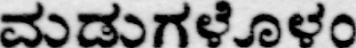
ಮಡುಗಳೊಳಂ
